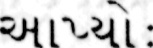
આપ્યો:
